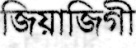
জিয়াজিগী
